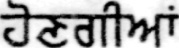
ਹੋਣਗੀਆਂ
